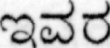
ಇವರ
